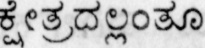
ಕ್ಷೇತ್ರದಲ್ಲಂತೂ
